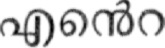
എന്റെ
